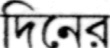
দিনের
